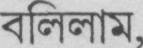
বলিলাম,
